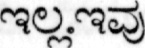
ಇಲ್ಲ.ಇವು
